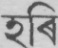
হৰি
